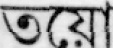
তয়ো
